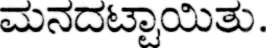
ಮನದಟ್ಟಾಯಿತು.
